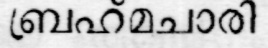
ബ്രഹ്മചാരി
